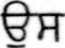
ਉਸ
